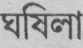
ঘষিলা
